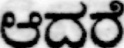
ಆದರೆ
